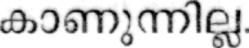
കാണുന്നില്ല.
